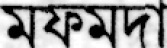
মফমদা
